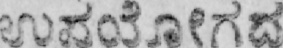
ಉಪಯೋಗದ
